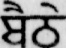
ਬੈਠੇ
